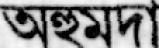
অহুমদা
